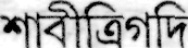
শাবীত্রিগদি
